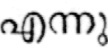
എന്നു
